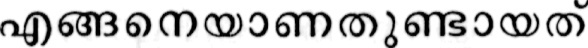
എങ്ങനെയാണതുണ്ടായത്
